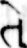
તે
